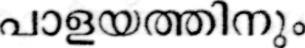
പാളയത്തിനും
